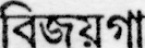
বিজয়গা
